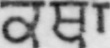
ਕਥਾ
